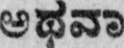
ಅಥವಾ
